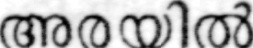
അരയില്‍
